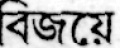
বিজয়ে
